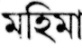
মহিমা
